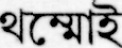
থম্মোই
